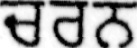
ਚਰਨ
